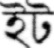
ইট
